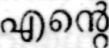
എന്റെ
